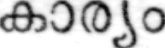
കാര്യം
